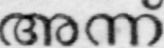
അന്ന്
